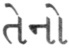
તેનો
